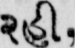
રહી,
